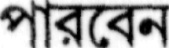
পারবেন
